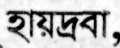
হায়দ্রবা,
